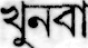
খুনবা
